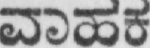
ವಾಹಕ
